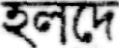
হলদে
